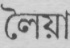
লৈয়া
